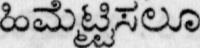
ಹಿಮ್ಮೆಟ್ಟಿಸಲೂ
